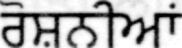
ਰੋਸ਼ਨੀਆਂ
